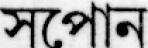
সপোন
